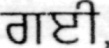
ਗਈ,
